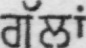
ਗੱਲਾਂ
